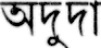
অদুদা
